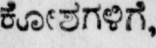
ಕೋಶಗಳಿಗೆ,
